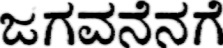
ಜಗವನೆನಗೆ
